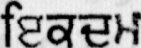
ਇਕਦਮ
